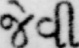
જેવી
